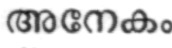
അനേകം
